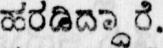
ಹರಡಿದ್ದಾರೆ.
